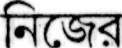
নিজের
